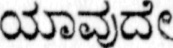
ಯಾವುದೇ
